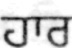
ਹਾਰ
